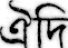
ঐদি
